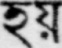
হয়
